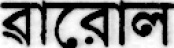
ৱারোল
